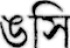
ঙসি
